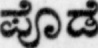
ಪೊಡೆ
